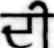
ਦੀ
